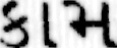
કામ
